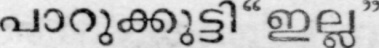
പാറുക്കുട്ടി"ഇല്ല"
